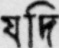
যদি
